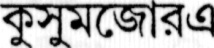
কুসুমজোরএ
